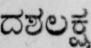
ದಶಲಕ್ಷ
